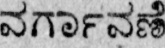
ವರ್ಗಾವಣೆ
